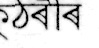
কুঠৰীৰ
